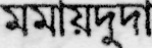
মমায়দুদা
